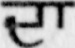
ਦਾ
